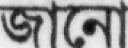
জানো
